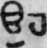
ਉਹ
